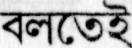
বলতেই
